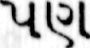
પણ
